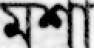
মশা
